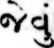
જેવું
